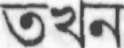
তখন
